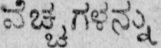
ವೆಚ್ಚಗಳನ್ನು
